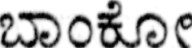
ಬಾಂಕೋ
